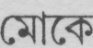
মোকে
